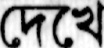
দেখে
